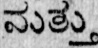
ಮತ್ತು
